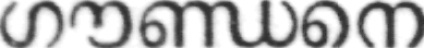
ഗൗണ്ഡനെ
